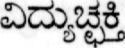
ವಿದ್ಯುಚ್ಛಕ್ತಿ
